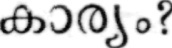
കാര്യം?
